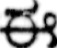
ಈ
